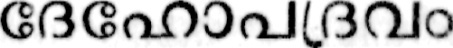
ദേഹോപദ്രവം
